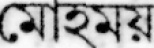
মোহময়
